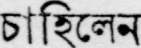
চাহিলেন
